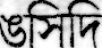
ঙসিদি
